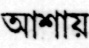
আশায়
